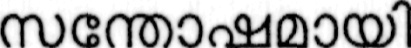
സന്തോഷമായി
